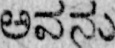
ಅವನು
